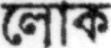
লোক
